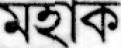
মহাক
